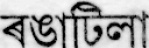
ৰঙাটিলা
